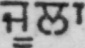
ਜੂਲਾ
